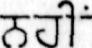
ਨਹੀਂ
